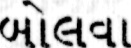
બોલવા
